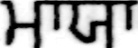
ਮਾਯਾ
